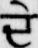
ਦੇ
